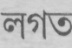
লগত
